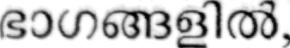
ഭാഗങ്ങളില്‍,
